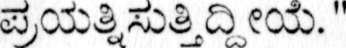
ಪ್ರಯತ್ನಿಸುತ್ತಿದ್ದೀಯೆ.”
